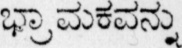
ಭ್ರಾಮಕವನ್ನು
